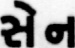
સેન
